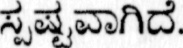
ಸ್ಪಷ್ಟವಾಗಿದೆ.
